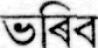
ভৰিব
